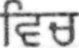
ਵਿਚ
